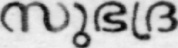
സുഭദ്ര
